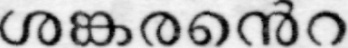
ശങ്കരന്റെ
